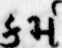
કર્મ
